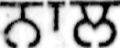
ਨਾਲ
